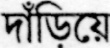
দাঁড়িয়ে
